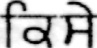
ਕਿਸੇ
